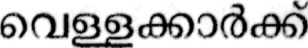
വെള്ളക്കാര്‍ക്ക്
